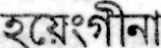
হয়েংগীনা
